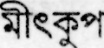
মীৎকুপ
